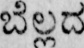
ಬೆಲ್ಲದ
